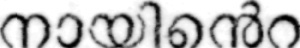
നായിന്റെ
